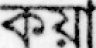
কয়া
